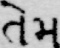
તેમ
